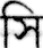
সি
